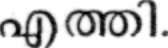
എത്തി.
